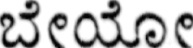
ಬೇಯೋ
